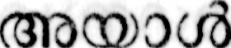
അയാള്‍
